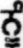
ਨੂੰ
